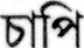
চাপি
